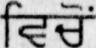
ਵਿਚੋਂ
